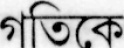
গতিকে
